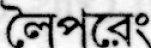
লৈপরেং
